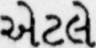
એટલે
